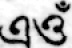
এওঁ
